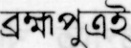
ব্রহ্মপুত্রই
